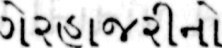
ગેરહાજરીનો
